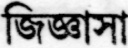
জিজ্ঞাসা
